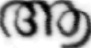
ആ
